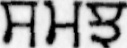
ਸਮਝ
